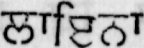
ਲਾਇਨਾ
